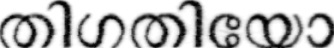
തിഗതിയോ
